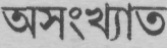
অসংখ্যাত
